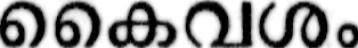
കൈവശം
